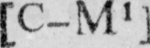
IC-M]
